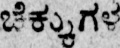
ಚೆಕ್ಕುಗಳ
